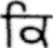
ਕਿ
